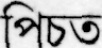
পিচত
